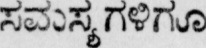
ಸಮಸ್ಯಗಳಿಗೂ
